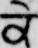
ਕੇ
